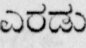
ಎರಡು
